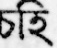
চহি
